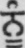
ਨੂੰ
